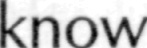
know
